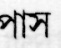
পাস
